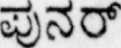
ಪುನರ್
